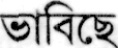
ভাবিছে
